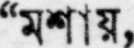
‘‘মশায়,
